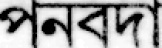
পনবদা
